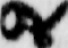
જ
